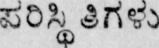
ಪರಿಸ್ಥಿತಿಗಳು
